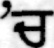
'ਚ
